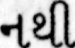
નથી
